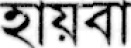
হায়বা
